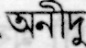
অনীদু
